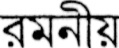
রমনীয়
